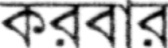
করবার
